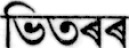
ভিতৰৰ
